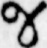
જ
